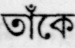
তাঁকে
